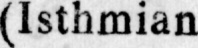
(Isthmian
